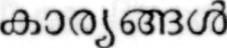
കാര്യങ്ങള്‍
